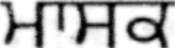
ਮਾਸਕ
